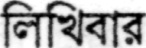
লিখিবার
